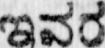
ಇವರ
